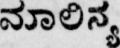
ಮಾಲಿನ್ಯ
